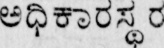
ಅಧಿಕಾರಸ್ಥರ
